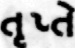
તૃપ્તે
